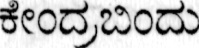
ಕೇಂದ್ರಬಿಂದು
